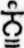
ਨੂੰ
